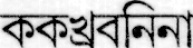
ককখ্রবনিনা
